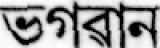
ভগৱান
